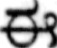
ಈ
